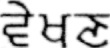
ਵੇਖਣ
